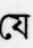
যে
